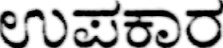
ಉಪಕಾರ
